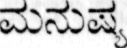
ಮನುಷ್ಯ
